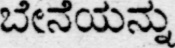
ಬೇನೆಯನ್ನು
